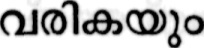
വരികയും
